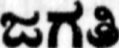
ಜಗತಿ
